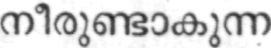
നീരുണ്ടാകുന്ന
